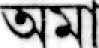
অমা
